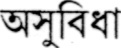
অসুবিধা
